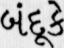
બંદૂકે
